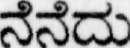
ನೆನೆದು
